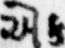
એક
